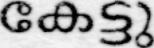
കേട്ടു
